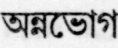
অন্নভোগ
